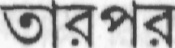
তারপর
